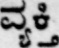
ವ್ಯಕ್ತಿ
